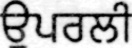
ਉਪਰਲੀ
